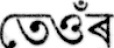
তেওঁৰ
